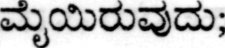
ಮೈಯಿರುವುದು;
